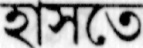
হাসতে
